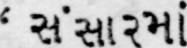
'સંસારમાં
